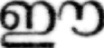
ഈ
